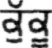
ਕੁੱਕੂ
